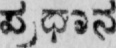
ಪ್ರಧಾನ
